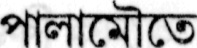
পালামৌতে
